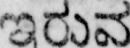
ಇರುವ
